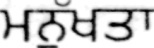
ਮਨੁੱਖਤਾ
